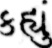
કહ્યું
